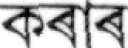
কৰাৰ
